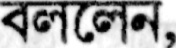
বললেন,
